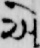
એ
